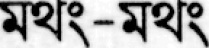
মথং-মথং
